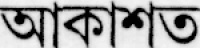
আকাশত
